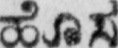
ಹೊಸ
